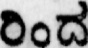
ರಿಂದ
